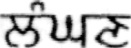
ਲੰਘਣ
